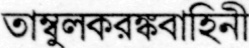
তাম্বুলকরঙ্কবাহিনী
